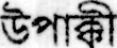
উপাক্কী
